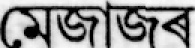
মেজাজৰ
